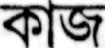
কাজ
